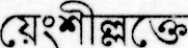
য়েংশীল্লক্তে
